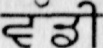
ਵੱਡੀ
